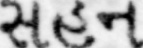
સહન
